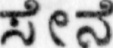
ಸೇನೆ
